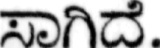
ಸಾಗಿದೆ.
